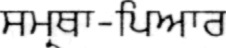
ਸਮ੍ਰਥਾ-ਪਿਆਰ
